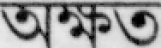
অক্ষত
